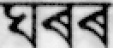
ঘৰৰ
